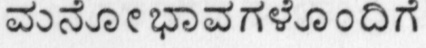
ಮನೋಭಾವಗಳೊಂದಿಗೆ
